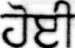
ਹੋਈ
